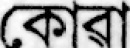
কোৱা
